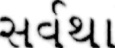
સર્વથા
